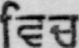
ਵਿਚ
